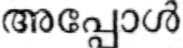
അപ്പോള്‍
